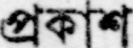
প্রকাশ
